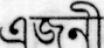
এজনী
